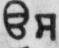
ਉਸ
